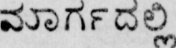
ಮಾರ್ಗದಲ್ಲಿ
